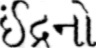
ઈન્દ્રનો
